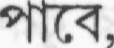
পাবে,
